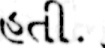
હતી.
